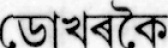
ডোখৰকৈ
